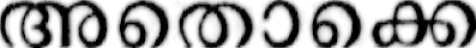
അതൊക്കെ
